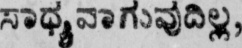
ಸಾಧ್ಯವಾಗುವುದಿಲ್ಲ,
